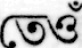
তেওঁ
